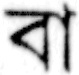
বা
